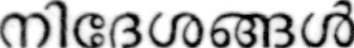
നിദേശങ്ങള്‍
